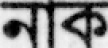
নাক
